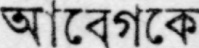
আবেগকে
